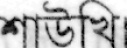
শাউখি।
